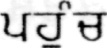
ਪਹੁੰਚ
